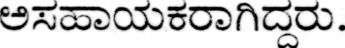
ಅಸಹಾಯಕರಾಗಿದ್ದರು.
